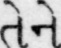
તેને
